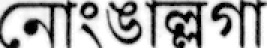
নোংঙাল্লগা
